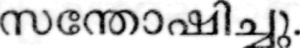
സന്തോഷിച്ചു.
